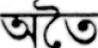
অতৈ
